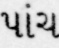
પાંચ
